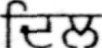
ਦਿਲ
